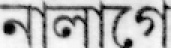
নালাগে
